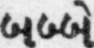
બબ્બે
